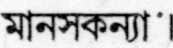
মানসকন্যা'।
